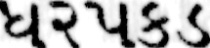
ધરપકડ
